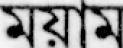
ময়াম
